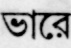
ভারে
